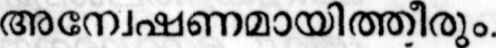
അന്വേഷണമായിത്തീരും.
